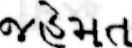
જહેમત
